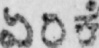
ಏರಿಕೆ
